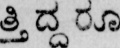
ತ್ತಿದ್ದರೂ
